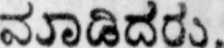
ಮಾಡಿದರು.
